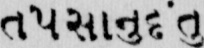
તપસાનુદંતુ
